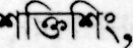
শক্তিশিং,
